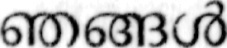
ഞങ്ങള്‍
